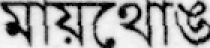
মায়থোঙ
